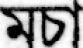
মচা
